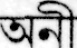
অনী
